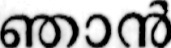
ഞാന്‍
